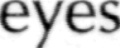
eyes
